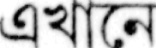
এখানে
